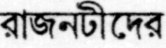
রাজনটীদের
